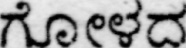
ಗೋಳದ
